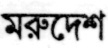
মরুদেশ
